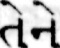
તેને
